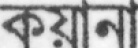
কয়ানা
